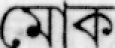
মোক
